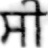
ਸੀ
